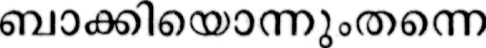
ബാക്കിയൊന്നുംതന്നെ
